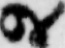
જ
